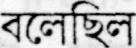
বলেছিল
